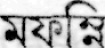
মফম্নি
